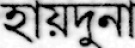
হায়দুনা
